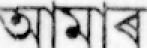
আমাৰ
